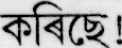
কৰিছে!
